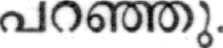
പറഞ്ഞു.
